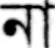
না
